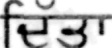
ਦਿੱਤਾ
